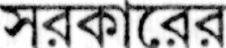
সরকারের
